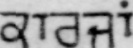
ਕਾਰਜਾਂ
